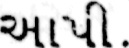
આપી.
